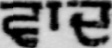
ਵਾਦ
